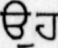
ਉਹ
